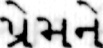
પ્રેમને
